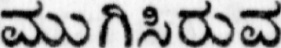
ಮುಗಿಸಿರುವ
